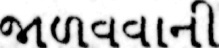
જાળવવાની
